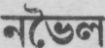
নভৈল
